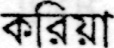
করিয়া
